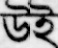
উই
